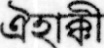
ঐহাক্কী
